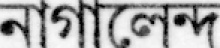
নাগালেন্দ
